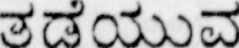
ತಡೆಯುವ
